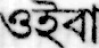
ওইবা
